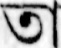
তা
